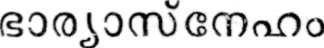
ഭാര്യാസ്നേഹം
